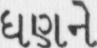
ધણને
